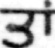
ਤਾਂ
